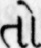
તો
